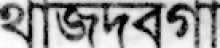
থাজদবগা
